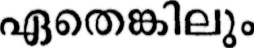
ഏതെങ്കിലും
